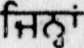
ਜਿਨ੍ਹਾਂ
